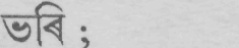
ভৰি;
